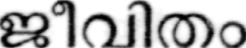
ജീവിതം
